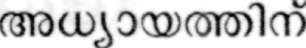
അധ്യായത്തിന്
